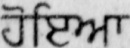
ਹੋਇਆ
